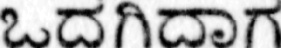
ಒದಗಿದಾಗ
